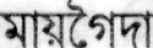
মায়গৈদা
